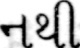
નથી
